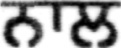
ਨਾਲ
